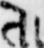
તો
